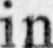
in
